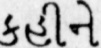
કહીને
